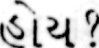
હોય?
